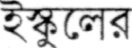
ইস্কুলের
